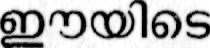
ഈയിടെ
